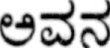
ಅವನ
